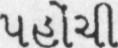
પહોંચી
